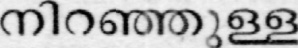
നിറഞ്ഞുള്ള
